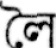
লৈ
